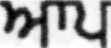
ਆਪ
